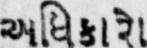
અધિકારો
